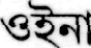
ওইনা
